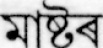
মাষ্টৰ
